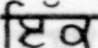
ਇੱਕ
